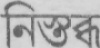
নিস্তব্ধ
